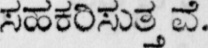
ಸಹಕರಿಸುತ್ತವೆ.
